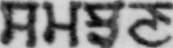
ਸਮਝਣ
